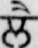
ਲੈ
